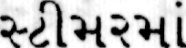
સ્ટીમરમાં
